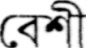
বেশী
